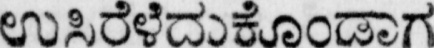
ಉಸಿರೆಳೆದುಕೊಂಡಾಗ
